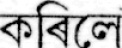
কৰিলে
